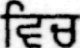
ਵਿਚ
